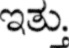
ಇತ್ತು.
